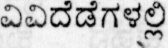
ವಿವಿದೆಡೆಗಳಲ್ಲಿ
